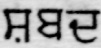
ਸ਼ਬਦ
